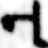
ન
